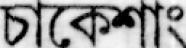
চাকেশাং
